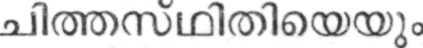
ചിത്തസ്ഥിതിയെയും
